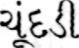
ચૂંદડી
